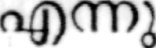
എന്നു
